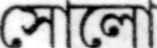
সোলো
